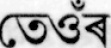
তেওঁৰ
